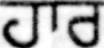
ਹਾਰ
